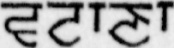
ਵਟਾਣਾ
